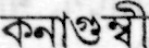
কনাগুম্বী
